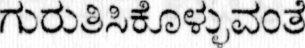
ಗುರುತಿಸಿಕೊಳ್ಳುವಂತೆ
